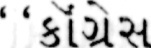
"કૉંગ્રેસ
